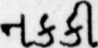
નકકી
